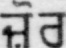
ਜ਼ੋਰ
